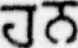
ਹਨ
